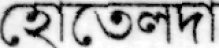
হোতেলদা
